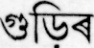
গুড়িৰ
